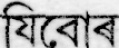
যিবোৰ
